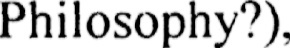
Philosophy?),
